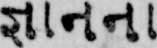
જ્ઞાનના
